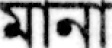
মানা
